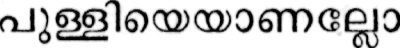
പുള്ളിയെയാണല്ലോ
